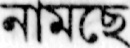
নামছে
